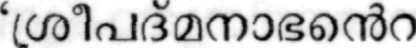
'ശ്രീപദ്മനാഭന്റെ
